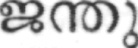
ജന്തു
